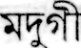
মদুগী
